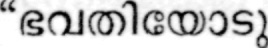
“ഭവതിയോടു
